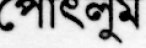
পোৎলুম
